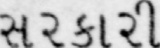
સરકારી
